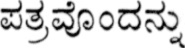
ಪತ್ರವೊಂದನ್ನು
